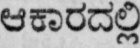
ಆಕಾರದಲ್ಲಿ
